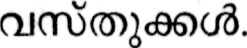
വസ്തുക്കള്‍.
